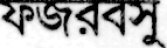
ফজরবসু
